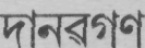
দানৱগণ
